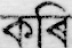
কৰি
